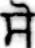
ਸੋ
